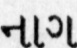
નાગ
